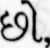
છો,
